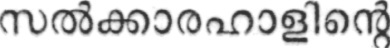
സല്‍ക്കാരഹാളിന്റെ
